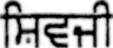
ਸ਼ਿਵਜੀ
